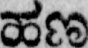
ಹಣ
